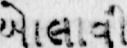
બોલાવી
